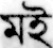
মই
